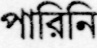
পারিনি
